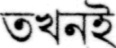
তখনই
